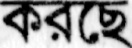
করছে
